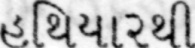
હથિયારથી
